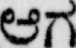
ಆಗ
